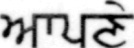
ਆਪਣੇ
